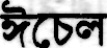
ঈচেল
